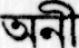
অনী
